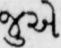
જુએ
